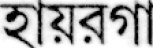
হায়রগা
